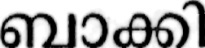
ബാക്കി
